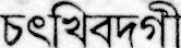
চৎখিবদগী
